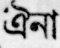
ঐনা
